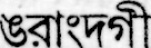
ঙরাংদগী
